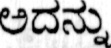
ಅದನ್ನು
